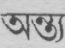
অন্ত্য
